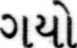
ગયો
